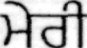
ਮੇਰੀ
